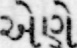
એણે
